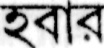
হবার
